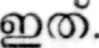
ഇത്.
